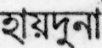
হায়দুনা
